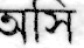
অসি
